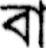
বা
